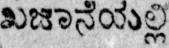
ಖಜಾನೆಯಲ್ಲಿ
